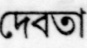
দেবতা
